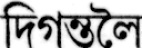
দিগন্তলৈ
